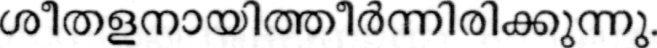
ശീതളനായിത്തീര്‍ന്നിരിക്കുന്നു.
